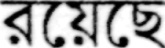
রয়েছে
